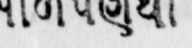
બાળપણથી
